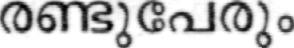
രണ്ടുപേരും
